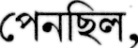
পেনছিল,
